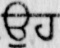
ਉਹ
